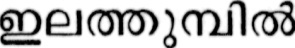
ഇലത്തുമ്പില്‍
